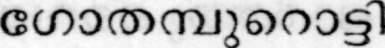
ഗോതമ്പുറൊട്ടി
